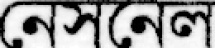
নেসনেল
